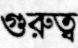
গুরুত্ব
